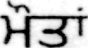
ਮੌਤਾਂ
